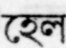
হেল
